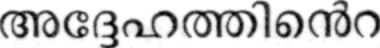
അദ്ദേഹത്തിന്റെ
